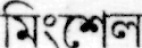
মিংশেল
